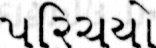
પરિચયો
